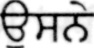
ਉਸਨੇ
